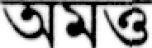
অমত্ত
